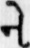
ને
